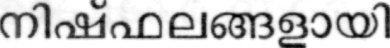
നിഷ്ഫലങ്ങളായി
